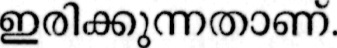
ഇരിക്കുന്നതാണ്.
